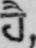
ਹੈ,
